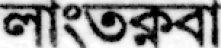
লাংতক্নবা
